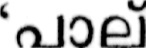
‘പാല്
